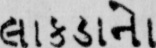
લાકડાનો
